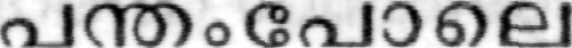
പന്തംപോലെ
